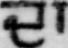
ਦਾ
